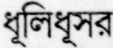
ধূলিধূসর
